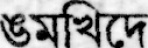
ঙমখিদে
